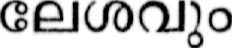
ലേശവും
